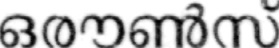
ഒരൌണ്‍സ്
